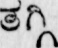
ತಗ್ಗಿ
